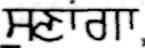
ਸੁਣਾਂਗਾ,
